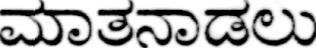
ಮಾತನಾಡಲು
